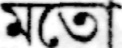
মতো
